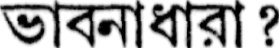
ভাবনাধারা?
